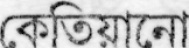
কেতিয়ানো
